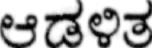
ಆಡಳಿತ
